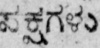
ಪಕ್ಷಗಳು
